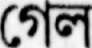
গেল
